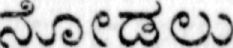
ನೋಡಲು
